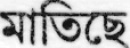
মাতিছে
